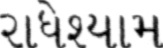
રાધેશ્યામ
